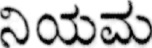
ನಿಯಮ
